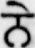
ਨੇ
